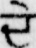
ਦੇ
